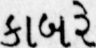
કાબરે
